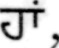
ਹਾਂ,
